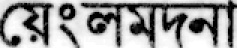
য়েংলমদনা
